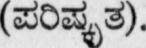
(ಪರಿಷ್ಕೃತ).
